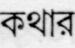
কথার
